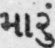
મારું
